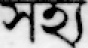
সহ্য
